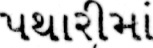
પથારીમાં
